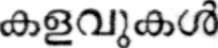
കളവുകള്‍
